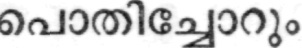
പൊതിച്ചോറും
